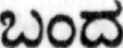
ಬಂದ
